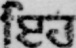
ਇਹ
